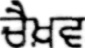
ਚੈਖ਼ਵ
